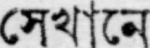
সেখানে
